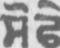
ਸੋਫੇ
